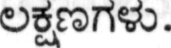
ಲಕ್ಷಣಗಳು.
